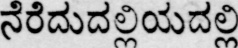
ನೆರೆದುದಲ್ಲಿಯದಲ್ಲಿ
